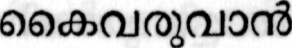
കൈവരുവാന്‍
